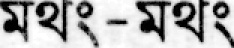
মথং-মথং
